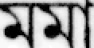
মমা
